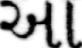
આ
